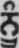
ਨੂੰ
